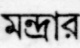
মন্দ্রার
